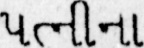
પત્નીના
